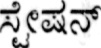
ಸ್ಟೇಷನ್
